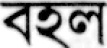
বহল
